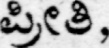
ಪ್ರೀತಿ,
